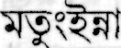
মতুংইন্না
